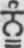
ਨੂੰ
